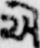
એ
